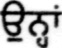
ਉਨ੍ਹਾਂ
